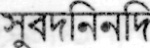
সুবদনিনদি
